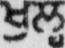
ਖੁਲ੍ਹ
